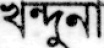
খন্দুনা
